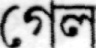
গেল
